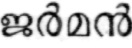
ജര്‍മന്‍
